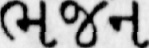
ભજન
